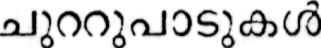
ചുററുപാടുകള്‍
